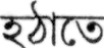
হঠাতে
